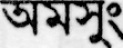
অমসুং
